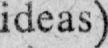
ideas)
